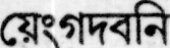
য়েংগদবনি
